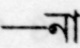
–না
